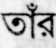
তাঁর
